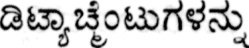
ಡಿಟ್ಯಾಚ್ಮೆಂಟುಗಳನ್ನು
